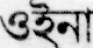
ওইনা
